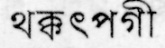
থক্কৎপগী
